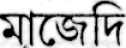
মাজেদি
